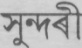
সুন্দৰী
